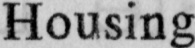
Housing
